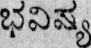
ಭವಿಷ್ಯ
